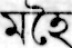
মহৈ
